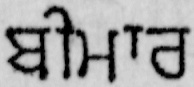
ਬੀਮਾਰ
